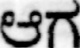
ಆಗ
